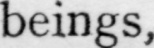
beings,
